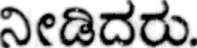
ನೀಡಿದರು.
